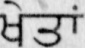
ਖੇਤਾਂ
